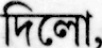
দিলো,
